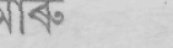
আৰু
